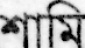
শামি
